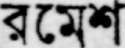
রমেশ
